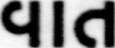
વાત
